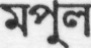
মপুল
